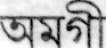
অমগী
